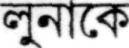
লুনাকে
